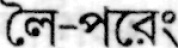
লৈ-পরেং
